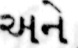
અને
